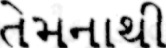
તેમનાથી
